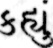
કહ્યું
